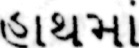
હાથમાં
